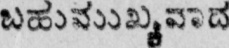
ಬಹುಮುಖ್ಯವಾದ
